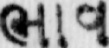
ભાવ
